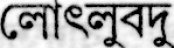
লোৎলুবদু
